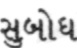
સુબોધ
